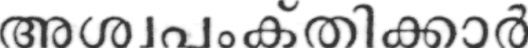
അശ്വപംക്തിക്കാര്‍
